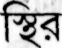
স্থির
